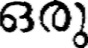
ഒരു
